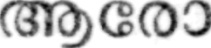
ആരോ
